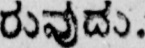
ರುವುದು.
